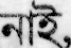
নাই,
